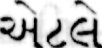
એટલે
